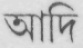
আদি
